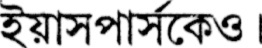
ইয়াসপার্সকেও।
